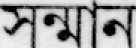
সন্মান
